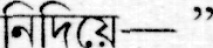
নিদিয়ে-"
